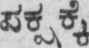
ಪಕ್ಷಕ್ಕೆ
